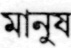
মানুষ
